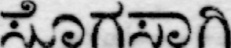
ಸೊಗಸಾಗಿ
